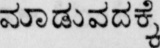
ಮಾಡುವದಕ್ಕೆ
